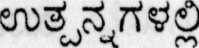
ಉತ್ಪನ್ನಗಳಲ್ಲಿ
